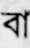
বা
